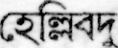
হেল্লিবদু
